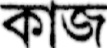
কাজ
